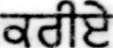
ਕਰੀਏ
